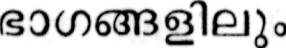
ഭാഗങ്ങളിലും
